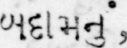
બદામનું,
